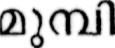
മുമ്പി
